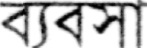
ব্যবসা
